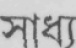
সাধ্য
